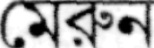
মেরুন
